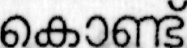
കൊണ്ട്
